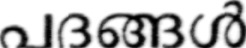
പദങ്ങള്‍
